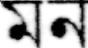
মন
